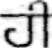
ਹੀ
